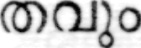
തവും
